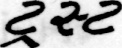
ટ્રસ્ટ
